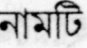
নামটি
